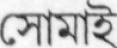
সোমাই
